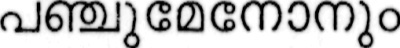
പഞ്ചുമേനോനും
